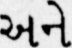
અને
